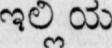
ಇಲ್ಲಿಯ
